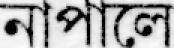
নাপালে
